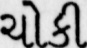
ચોકી
